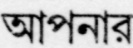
আপনার
